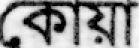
কোয়া
